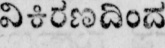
ವಿಕಿರಣದಿಂದ
